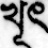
খূৎ
